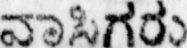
ವಾಸಿಗರು
